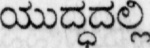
ಯುದ್ಧದಲ್ಲಿ
